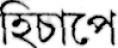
হিচাপে
